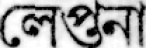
লেপ্তনা
